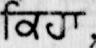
ਕਿਹਾ,
